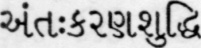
અંતઃકરણશુદ્ધિ
